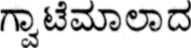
ಗ್ವಾಟೆಮಾಲಾದ
